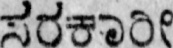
ಸರಕಾರೀ
